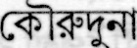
কৌরুদুনা
